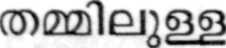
തമ്മിലുള്ള
